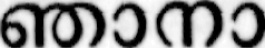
ഞാനാ
